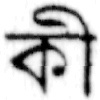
কী
